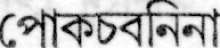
পোকচবনিনা
